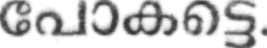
പോകട്ടെ.
